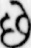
છે
